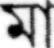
মা
